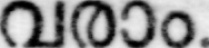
വരാം.
